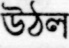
উঠল
